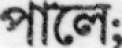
পালে;
